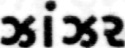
ઝાંઝર
